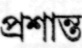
প্রশান্ত
